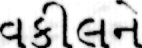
વકીલને
